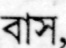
বাস,
